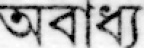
অবাধ্য
